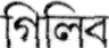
গিলিব
